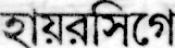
হায়রসিগে
